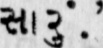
સારું.'
